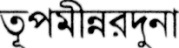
তূপমীন্নরদুনা
